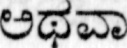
ಅಥವಾ
